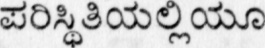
ಪರಿಸ್ಥಿತಿಯಲ್ಲಿಯೂ
